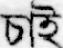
চাই
